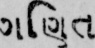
ગણિત
